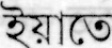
ইয়াতে
